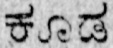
ಕೂಡ
